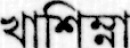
খাশিম্না
